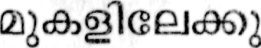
മുകളിലേക്കു
